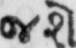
જશે
